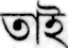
তাই
